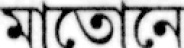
মাতোনে
